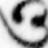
ও
